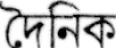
দৈনিক
